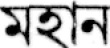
মহান
